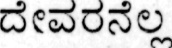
ದೇವರನೆಲ್ಲ
